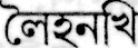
লৈহনখি
